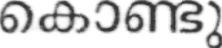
കൊണ്ടു
